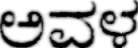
ಅವಳ
